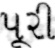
પૂરી
